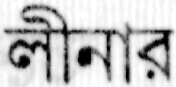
লীনার
